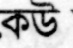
কেউ
